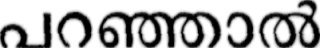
പറഞ്ഞാല്‍
